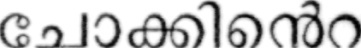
ചോക്കിന്റെ
